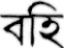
বহি
